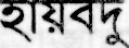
হায়বদু
